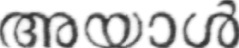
അയാള്‍
